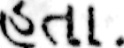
હતા.
